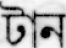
টান
